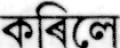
কৰিলে
